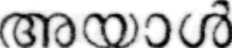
അയാള്‍
